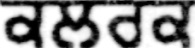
ਕਲਰਕ
